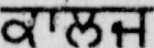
ਕਾਲਜ
